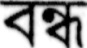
বন্ধ
